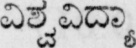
ವಿಶ್ವವಿದ್ಯಾ
